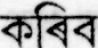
কৰিব
